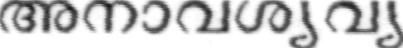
അനാവശ്യവ്യ
